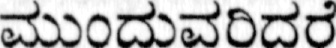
ಮುಂದುವರಿದರೆ
